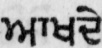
ਆਖਦੇ
